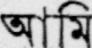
আমি
